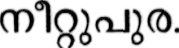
നീറ്റുപുര.
